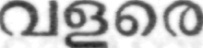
വളരെ
